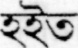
হইত
